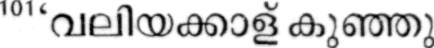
101'വലിയക്കാള്കുഞ്ഞു
